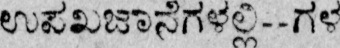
ಉಪಖಜಾನೆಗಳಲ್ಲಿ--ಗಳ
